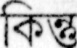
কিন্তু
